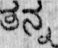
ತನ್ನ
